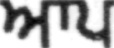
ਆਪ
